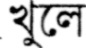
খুলে
